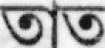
তাত
